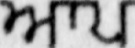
ਆਪ
